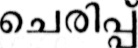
ചെരിപ്പ്
